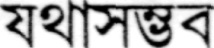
যথাসম্ভব
